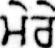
ਮੇਰੇ
